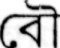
বৌ
